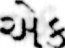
એક
